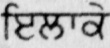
ਇਲਾਕੇ
